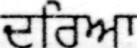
ਦਰਿਆ
